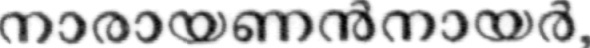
നാരായണന്‍നായര്‍,
